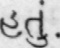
હતું.
